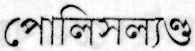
পোলিসল্যণ্ড
